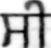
ਸੀ
